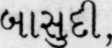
બાસુદી,
